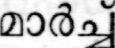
മാര്‍ച്ച്
